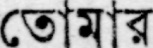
তোমার
